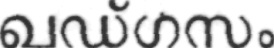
ഖഡ്ഗസം
